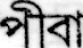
পীবা
